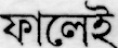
ফালেই
